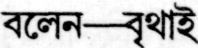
বলেন–বৃথাই
